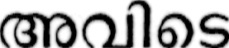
അവിടെ
